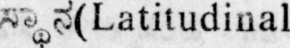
ಸ್ಥಾನ(Latitudinal
